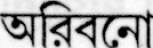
অরিবনো
